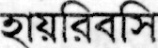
হায়রিবসি
